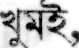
খুমই,
